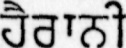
ਹੈਰਾਨੀ
